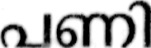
പണി
